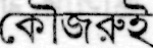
কৌজরুই
